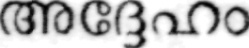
അദ്ദേഹം
